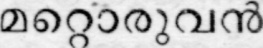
മറ്റൊരുവന്‍
